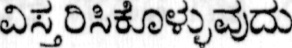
ವಿಸ್ತರಿಸಿಕೊಳ್ಳುವುದು
